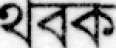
থবক
